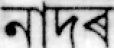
নাদৰ
